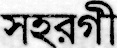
সহরগী
